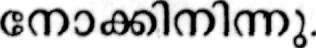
നോക്കിനിന്നു.
